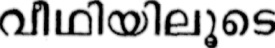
വീഥിയിലൂടെ
